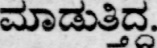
ಮಾಡುತ್ತಿದ್ದ.
